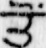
ਤੋਂ
